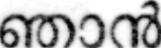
ഞാന്‍
